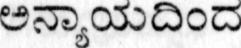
ಅನ್ಯಾಯದಿಂದ
